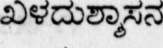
ಖಳದುಶ್ಯಾಸನ
